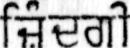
ਜ਼ਿੰਦਗੀ
